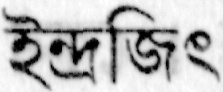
ইন্দ্রজিৎ
